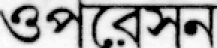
ওপরেসন
